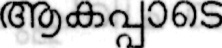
ആകപ്പാടെ
